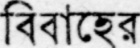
বিবাহের
